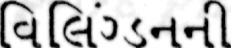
વિલિંગ્ડનની
